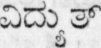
ವಿದ್ಯುತ್
